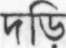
দড়ি
